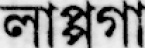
লাপ্পগা
